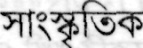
সাংস্কৃতিক
